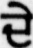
ਦੇ
